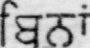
ਬਿਨਾਂ
